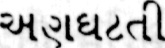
અણઘટતી
